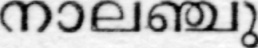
നാലഞ്ചു
